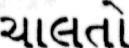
ચાલતો
